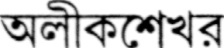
অলীকশেখর
